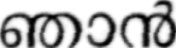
ഞാന്‍
